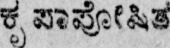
ಕೃಪಾಪೋಷಿತ
